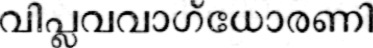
വിപ്ലവവാഗ്ധോരണി
